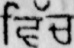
ਵਿੱਚ
